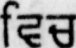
ਵਿਚ
